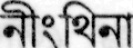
নীংথিনা
